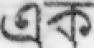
এক
